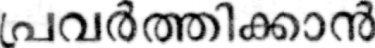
പ്രവര്‍ത്തിക്കാന്‍
